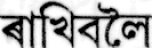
ৰাখিবলৈ
